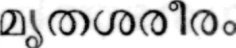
മൃതശരീരം
